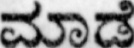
ಮಾಡೆ
